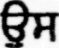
ਉਸ
